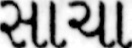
સાચા
